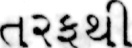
તરફથી
